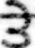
ਤੇ
